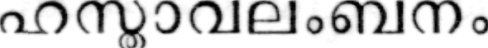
ഹസ്താവലംബനം
